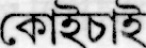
কোইচাই
